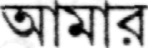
আমার
